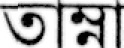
তাম্না
